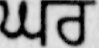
ਘਰ
